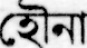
হৌনা
